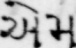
એમ
